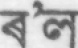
ৰ'ল
